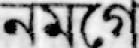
নমগে
